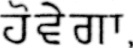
ਹੋਵੇਗਾ,
